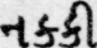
નક્કી
